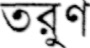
তরুণ
